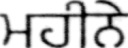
ਮਹੀਨੇ
